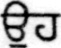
ਉਹ
